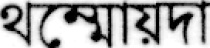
থম্মোয়দা
